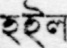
হইল
